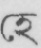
হে
